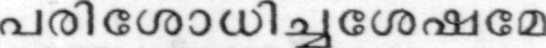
പരിശോധിച്ചശേഷമേ
